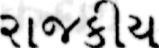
રાજકીય
